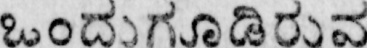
ಒಂದುಗೂಡಿರುವ
